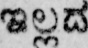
ಇಲ್ಲದ
